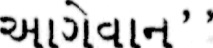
આગેવાન"
